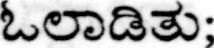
ಓಲಾಡಿತು;
